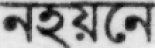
নহয়নে
